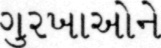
ગુરખાઓને
